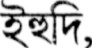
ইহুদি,
